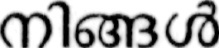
നിങ്ങള്‍
